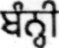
ਬੰਨ੍ਹੀ
